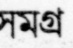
সমগ্র
